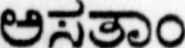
ಅಸತಾ೦
